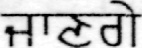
ਜਾਣਗੇ
